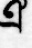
ঐ
